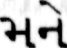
મને
